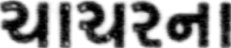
ચાચરના
